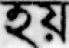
হয়
